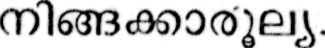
നിങ്ങക്കാരൂല്യ.
